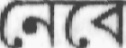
নেবে
